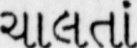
ચાલતાં
